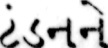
ટંડનને
